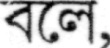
বলে,
